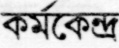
কর্মকেন্দ্র
